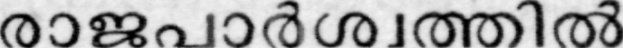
രാജപാര്‍ശ്വത്തില്‍
